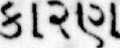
કારણ
